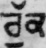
ਰੁੱਕ
